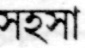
সহসা
